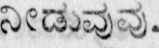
ನೀಡುವುವು.
